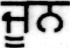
ਜੂਨ
